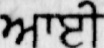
ਆਈ
